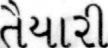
તૈયારી
